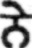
ਨੇ
